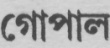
গোপাল
